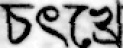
চৎখ্রে
